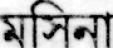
মসিনা
